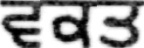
ਵਕਤ
